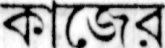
কাজের
